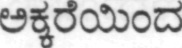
ಅಕ್ಕರೆಯಿಂದ
